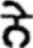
ਨੇ
